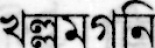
খল্লমগনি
